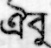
ইবু
